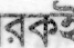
ইচঙ
